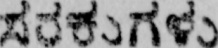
ಸರಕುಗಳು
